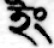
ইং
